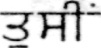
ਤੁਸੀ
